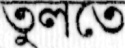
তুলতে
